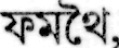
ফমথৈ,
